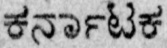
ಕರ್ನಾಟಕ
